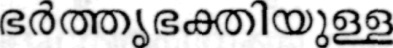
ഭര്‍ത്തൃഭക്തിയുള്ള
